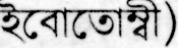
ইবোতোম্বী)
